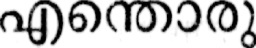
എന്തൊരു
